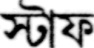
স্টাফ
